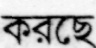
করছে
